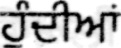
ਹੁੰਦੀਆਂ
